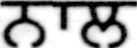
ਨਾਲ
